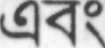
এবং
